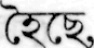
হৈছে,
